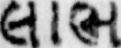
લાભ
